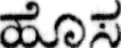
ಹೊಸ
